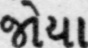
જોયા
